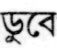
ডুবে
